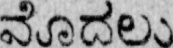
ಮೊದಲು
